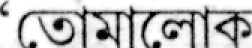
'তোমালোক
